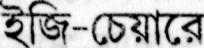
ইজি-চেয়ারে
